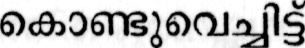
കൊണ്ടുവെച്ചിട്ട്
